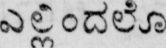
ಎಲ್ಲಿಂದಲೊ
